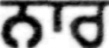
ਨਾਰ
